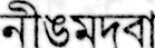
নীঙমদবা
